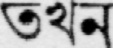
তখন
